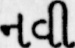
નવી
